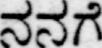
ನನಗೆ
